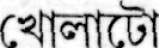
খোলাটো
